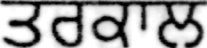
ਤਰਕਾਲ
